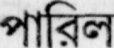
পারিল
